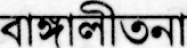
বাঙ্গালীতনা
